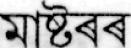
মাষ্টৰৰ
